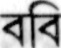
ববি
